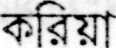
করিয়া
